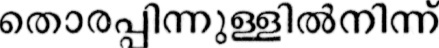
തൊരപ്പിന്നുള്ളില്‍നിന്ന്
